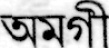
অমগী
